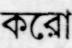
করো
